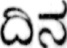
ದಿನ
